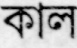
কাল
